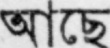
আছে
